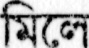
মিলে
